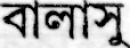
বালাসু
